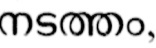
നടത്തം,
